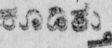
ಕೂಡಿತ್ತು
